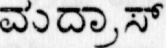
ಮದ್ರಾಸ್
